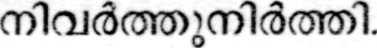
നിവര്‍ത്തുനിര്‍ത്തി.
